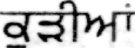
ਕੁੜੀਆਂ
